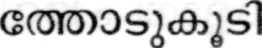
ത്തോടുകൂടി
